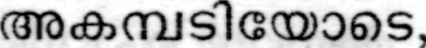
അകമ്പടിയോടെ,
